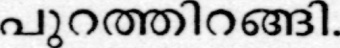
പുറത്തിറങ്ങി.
